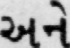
અને
